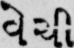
વેચી
